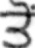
ਤੋਂ
